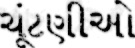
ચૂંટણીઓ
